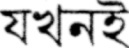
যখনই
